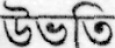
উভতি
